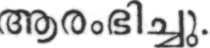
ആരംഭിച്ചു.
